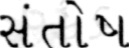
સંતોષ
